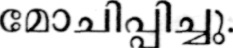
മോചിപ്പിച്ചു.
